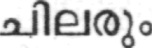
ചിലരും
